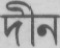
দীন
